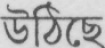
উঠিছে
